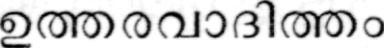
ഉത്തരവാദിത്തം
